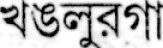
খঙলুরগা
